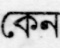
কেন
